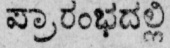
ಪ್ರಾರಂಭದಲ್ಲಿ
